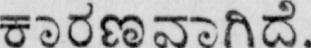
ಕಾರಣವಾಗಿದೆ.
